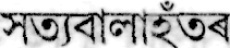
সত্যবালাহঁতৰ
